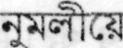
নুমলীয়ে
